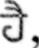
ਹੈ,
